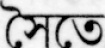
সৈতে
